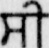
ਸੀ
